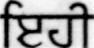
ਇਹੀ
